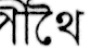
পীথৈ
